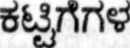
ಕಟ್ಟಿಗೆಗಳ
